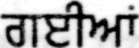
ਗਈਆਂ
